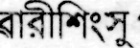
ৱারীশিংসু
